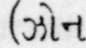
(ઝોન
